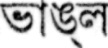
ভাঙ্ল
